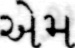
એમ
